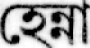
হেন্না
